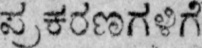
ಪ್ರಕರಣಗಳಿಗೆ
